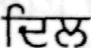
ਦਿਲ
